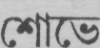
শোভে
